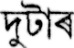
দুটাৰ
